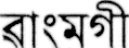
ৱাংমগী
